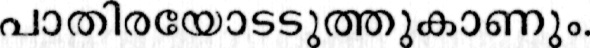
പാതിരയോടടുത്തുകാണും.
